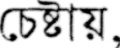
চেষ্টায়,
